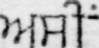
ਅਸੀਂ
